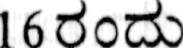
16ರಂದು
